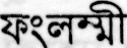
ফংলম্মী
